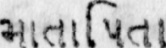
માતાપિતા
